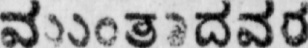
ಮುಂತಾದವರ
